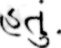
હતું.
